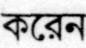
করেন
